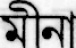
মীনা
